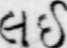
લઈ
